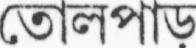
তোলপাড়
